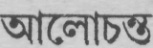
আলোচন্ত
